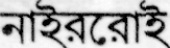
নাইররোই
